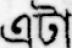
এটা
